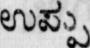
ಉಪ್ಪು
